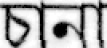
চানা
